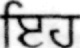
ਇਹ
